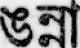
ঙন্না
